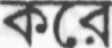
করে
